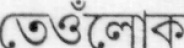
তেওঁলোক
